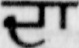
ਦਾ
